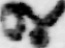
જ
